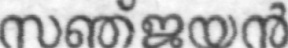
സഞ്ജയന്‍
